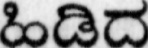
ಹಿಡಿದ
